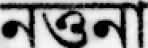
নত্তনা
